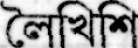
লৈখিশি
